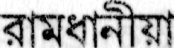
রামধানীয়া
